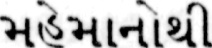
મહેમાનોથી
